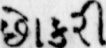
છોકરી
